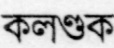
কলণ্ডক
